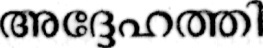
അദ്ദേഹത്തി
